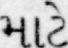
માટે
